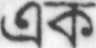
এক
